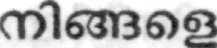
നിങ്ങളെ
